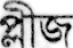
প্লীজ
